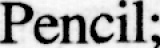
Pencil;
